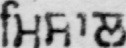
ਮਿਸਾਲ
